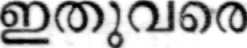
ഇതുവരെ
